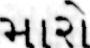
મારો
